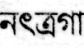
নৎত্রগা
